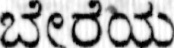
ಬೇರೆಯ
